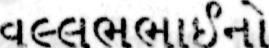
વલ્લભભાઈનો
